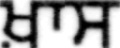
ਖ਼ਾਸ
